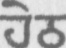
ਹੇਠ
